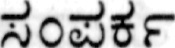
ಸಂಪರ್ಕ
